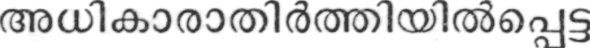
അധികാരാതിര്‍ത്തിയില്‍പ്പെട്ട
